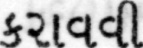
કરાવવી
